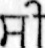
ਸੀ
